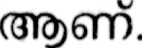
ആണ്.
